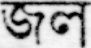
জল
